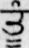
ਤੂੰ
